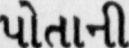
પોતાની
